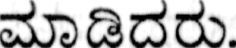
ಮಾಡಿದರು.
